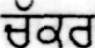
ਚੱਕਰ
